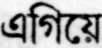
এগিয়ে
